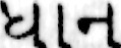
ધાન
